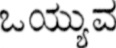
ಒಯ್ಯುವ
